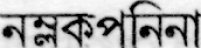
নম্লকপনিনা
